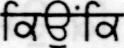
ਕਿਉਂਕਿ
